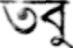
তবু
